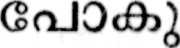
പോകു
